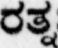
ರತ್ನ
